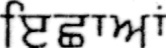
ਇਛਾਆਂ
